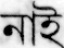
নাই
